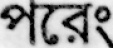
পরেং
